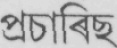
প্ৰচাৰিছ
